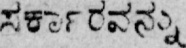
ಸರ್ಕಾರವನ್ನು
